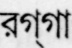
রগ্গা
